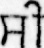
ਸੀ
